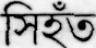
সিহঁত
